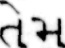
તેમ
